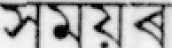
সময়ৰ
